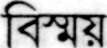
বিস্ময়
